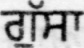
ਗੁੱਸਾ
